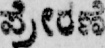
ಪ್ರೇರಣೆ
